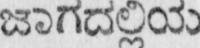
ಜಾಗದಲ್ಲಿಯ
